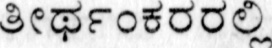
ತೀರ್ಥಂಕರರಲ್ಲಿ
